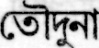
তৌদুনা
